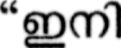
“ഇനി
